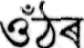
ওঁঠৰ
